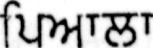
ਪਿਆਲਾ
